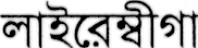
লাইরেম্বীগা
